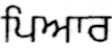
ਪਿਆਰ
